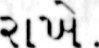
રાખે.
